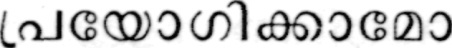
പ്രയോഗിക്കാമോ
